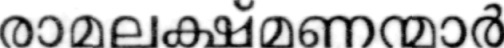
രാമലക്ഷ്മണന്മാര്‍
